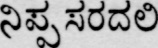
ನಿಪ್ಪಸರದಲಿ
